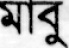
মাবু
